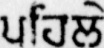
ਪਹਿਲੇ
